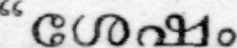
"ശേഷം
